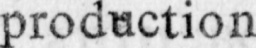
production
